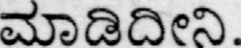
ಮಾಡಿದೀನಿ.
